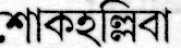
শোকহল্লিবা
